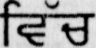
ਵਿੱਚ
